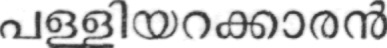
പള്ളിയറക്കാരന്‍
